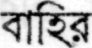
বাহির
